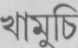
খামুচি
